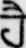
ਹੈ
